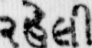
રહેલી
